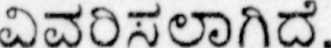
ವಿವರಿಸಲಾಗಿದೆ.
